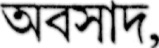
অবসাদ,
